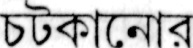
চটকানোর
